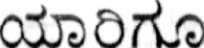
ಯಾರಿಗೂ
